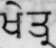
ਖੇਤ੍ਰ
